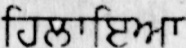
ਹਿਲਾਇਆ
